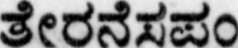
ತೇರನೆಸಪಂ
